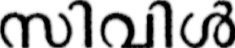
സിവിള്‍
